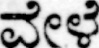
ವೇಳೆ
